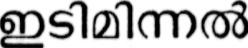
ഇടിമിന്നല്‍
